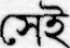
সেই
